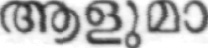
ആളുമാ
